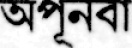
অপূনবা
